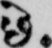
છે.
